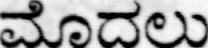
ಮೊದಲು
